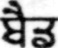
ਬੈਡ
